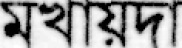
মখায়দা
